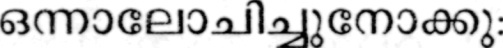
ഒന്നാലോചിച്ചുനോക്കു:
